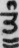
ਤੂੰ
